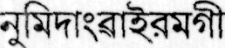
নুমিদাংৱাইরমগী
